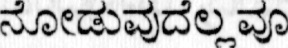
ನೋಡುವುದೆಲ್ಲವೂ
